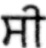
ਸੀ
